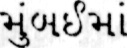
મુંબઈમાં
